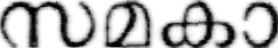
സമകാ
